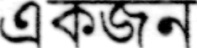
একজন
